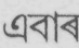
এবাৰ
